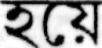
হয়ে
